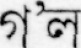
গ'ল
